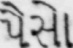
પૈસો
